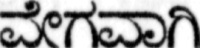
ವೇಗವಾಗಿ
